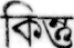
কিন্তু
